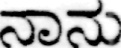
ನಾನು
